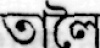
তালৈ
